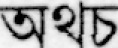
অথচ
